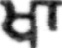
ਖਾ
